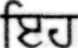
ਇਹ
